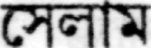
সেলাম
